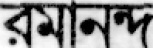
রমানন্দ
